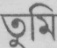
তুমি
